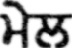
ਮੇਲ
